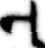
ન
